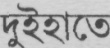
দুইহাতে
